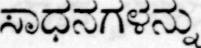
ಸಾಧನಗಳನ್ನು
